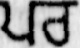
ਪਰ
